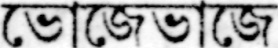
ভোজেভাজে
